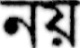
নয়
